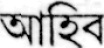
আহিব
